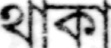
থাকা
